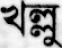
খল্লু
